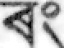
ৰং
